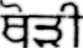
ਥੋੜੀ
